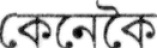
কেনেকৈ
